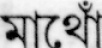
মাথোঁ
